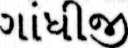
ગાંધીજી
